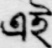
এই
